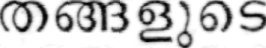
തങ്ങളുടെ
